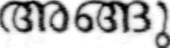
അങ്ങു
